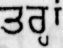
ਤਰ੍ਹਾਂ
